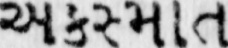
અકસ્માત
